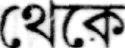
থেকে
